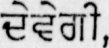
ਦੇਵੇਗੀ,
